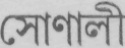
সোণালী
